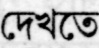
দেখতে
